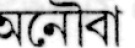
অনৌবা
